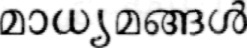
മാധ്യമങ്ങള്‍
